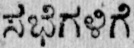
ಸಭೆಗಳಿಗೆ
